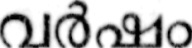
വര്‍ഷം
